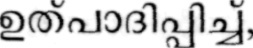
ഉത്പാദിപ്പിച്ച്,
